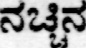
ನಚ್ಚಿನ
